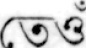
তেওঁ
